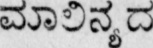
ಮಾಲಿನ್ಯದ
